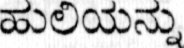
ಹುಲಿಯನ್ನು
